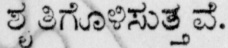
ಶೃತಿಗೊಳಿಸುತ್ತವೆ.
